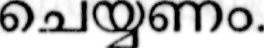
ചെയ്യണം.
